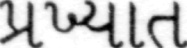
પ્રખ્યાત
